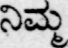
ನಿಮ್ಮ
